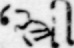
'સ્ત્રી
